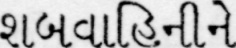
શબવાહિનીને
